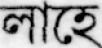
লাহে
